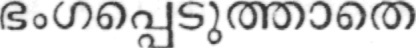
ഭംഗപ്പെടുത്താതെ
